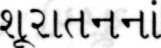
શૂરાતનનાં
